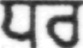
ਧਰ
